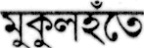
মুকুলহঁতে
